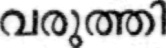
വരുത്തി
